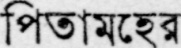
পিতামহের
